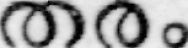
തരം
